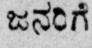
ಜನರಿಗೆ
